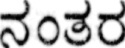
ನಂತರ
